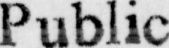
Public
